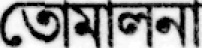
তোমালনা
